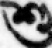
শু
